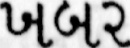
ખબર
